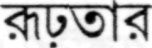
রূঢ়তার
